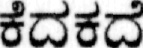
ಕೆದಕದೆ
